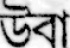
উবা
